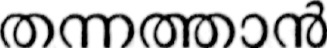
തന്നത്താന്‍
